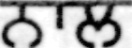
ਨਾਲ
